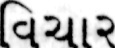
વિચાર
